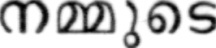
നമ്മുടെ
